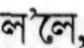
ল'লে,
